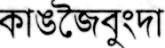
কাঙজৈবুংদা
